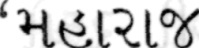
'મહારાજ
